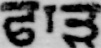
ਫਾੜ
